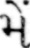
મેં
